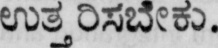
ಉತ್ತರಿಸಬೇಕು.
